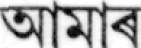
আমাৰ
